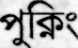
পুক্নিং
